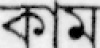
কাম
